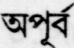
অপূর্ব
